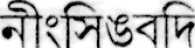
নীংসিঙবদি
